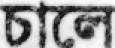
চালে
